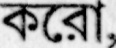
করো,
